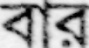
বার
